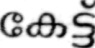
കേട്ട്
